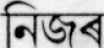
নিজৰ
